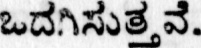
ಒದಗಿಸುತ್ತವೆ.
